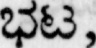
ಭಟ,
